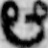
ಆ
